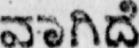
ವಾಗಿದೆ
